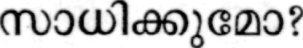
സാധിക്കുമോ?
